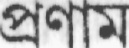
প্রণাম
